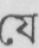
যে
